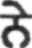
ਨੇ
